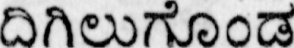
ದಿಗಿಲುಗೊಂಡ
